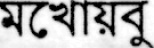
মখোয়বু
